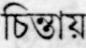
চিন্তায়
